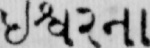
ઈશ્વરના
